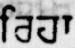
ਰਿਹਾ
